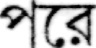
পরে
